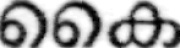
കൈ
